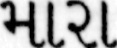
મારા
